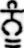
ਨੂੰ
